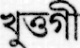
খুত্তগী
